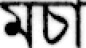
মচা
